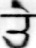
ਤੇ
